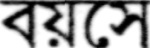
বয়সে
